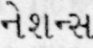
નેશન્સ
